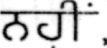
ਨਹੀਂ,
